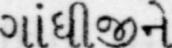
ગાંધીજીને
